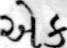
એક
